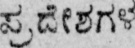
ಪ್ರದೇಶಗಳ
